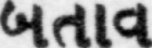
બતાવ
